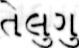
તેલુગુ
